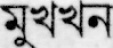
মুখখন
